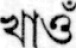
খাওঁ
